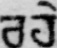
ਰਹੇ
